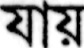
যায়
